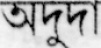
অদুদা
